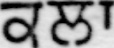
ਕਲਾ
